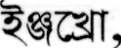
ইঞ্জখ্রো,
